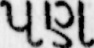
પણ
